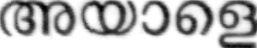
അയാളെ
